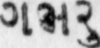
ગભરુ
